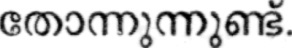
തോന്നുന്നുണ്ട്.
